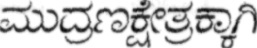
ಮುದ್ರಣಕ್ಷೇತ್ರಕ್ಕಾಗಿ
